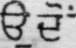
ਉਦੋਂ
